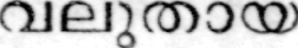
വലുതായ
